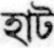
হাট
